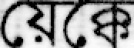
য়েক্কে
